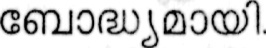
ബോദ്ധ്യമായി.
